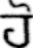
ਹੋ
